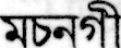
মচনগী
